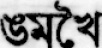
ঙমখৈ
